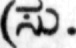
(ಸು.
